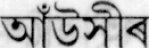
আঁউসীৰ
